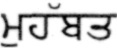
ਮੁਹੱਬਤ
